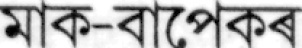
মাক-বাপেকৰ
